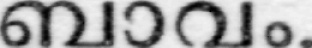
ബാവം.
